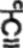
ਨੂੰ
